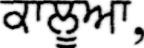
ਕਾਲੂਆ,
